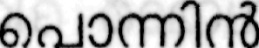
പൊന്നിന്‍
